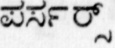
ಪರ್ಸರ್‍ಸ್
